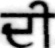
ਦੀ
